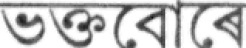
ভক্তবোৰে
